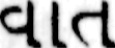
વાત
